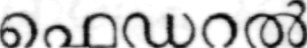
ഫെഡറല്‍
